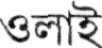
ওলাই
